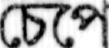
চেপে
